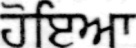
ਹੋਇਆ
